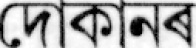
দোকানৰ
